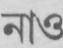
নাও
